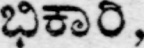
ಭಿಕಾರಿ,
